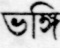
ভঙ্গি
